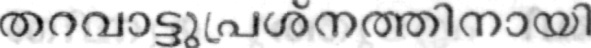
തറവാട്ടുപ്രശ്നത്തിനായി
